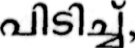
പിടിച്ച്,
